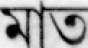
মাত
